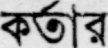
কর্তার
